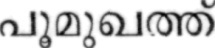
പൂമുഖത്ത്
